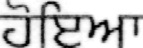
ਹੋਇਆ
